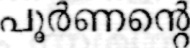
പൂര്‍ണന്റെ
